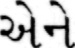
એને
